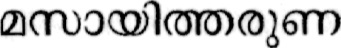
മസായിത്തരുണ
